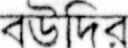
বউদির
